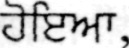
ਹੋਇਆ,
